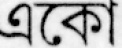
একো
